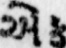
એક
